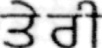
ਤੇਰੀ
